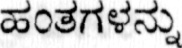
ಹಂತಗಳನ್ನು
